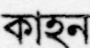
কাহন
